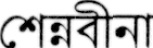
শেন্নবীনা
